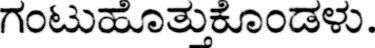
ಗಂಟುಹೊತ್ತುಕೊಂಡಳು.
